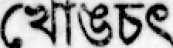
খোঙচৎ
